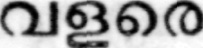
വളരെ
